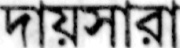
দায়সারা
